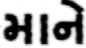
મને
